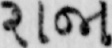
રાજા
